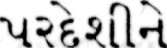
પરદેશીને
